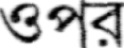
ওপর
